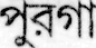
পুরগা
